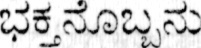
ಭಕ್ತನೊಬ್ಬನು
